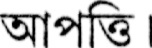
আপত্তি।
